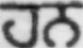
ਹਨ
